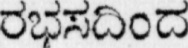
ರಭಸದಿಂದ
